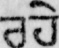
ਰਹੇ
